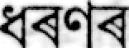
ধৰণৰ
